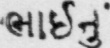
ભાઈનું
